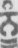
ਨੂੰ
